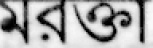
মরক্তা
